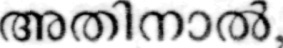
അതിനാല്‍,
